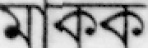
মাকক
